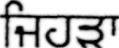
ਜਿਹੜਾ
